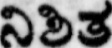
ನಿಶಿತ
